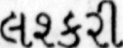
લશ્કરી
